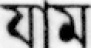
যাম
